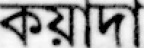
কয়াদা
